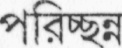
পরিচ্ছন্ন
